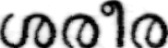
ശരീര
